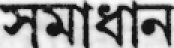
সমাধান
